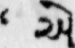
'એ
